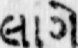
લાગે
